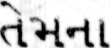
તેમના
